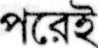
পরেই
